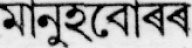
মানুহবোৰৰ
